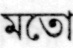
মতো
